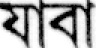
যাবা
